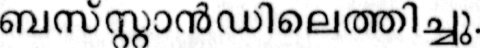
ബസ്സ്റ്റാന്‍ഡിലെത്തിച്ചു.
